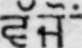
ਵੱਜੋਂ
